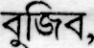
বুজিব,
